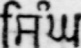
ਸਿੰਘ
